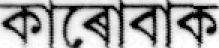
কাৰোবাক
